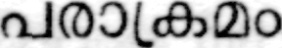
പരാക്രമം
